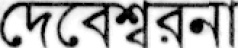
দেবেশ্বরনা
